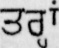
ਤਰ੍ਹਾਂ
